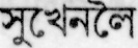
সুখেনলৈ
